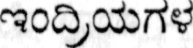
ಇಂದ್ರಿಯಗಳ
